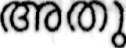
അതു
